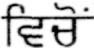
ਵਿਚੋਂ
